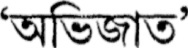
'অভিজাত'
